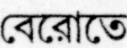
বেরোতে
